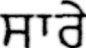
ਸਾਰੇ
